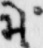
'મેં
